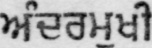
ਅੰਦਰਮੁਖੀ
